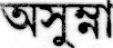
অসুম্না
